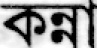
কন্না
